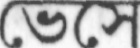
ভেসে
